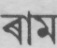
ৰাম
